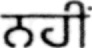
ਨਹੀਂ
